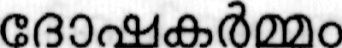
ദോഷകര്‍മ്മം
